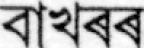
বাখৰৰ
